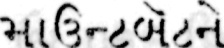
માઉન્ટબૅટને
